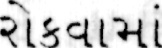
રોકવામાં
